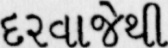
દરવાજેથી
